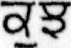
ਕੁਝ
